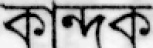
কান্দক
